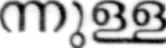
ന്നുള്ള
